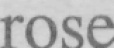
rose
